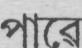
পাৱে
